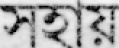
সহায়
